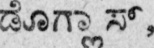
ಡೊಗ್ಲಾಸ್,
